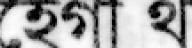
হেগা
